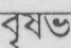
বৃষভ
